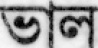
ভাল
